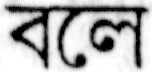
বলে
